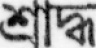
শ্রাদ্ধ
